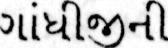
ગાંધીજીની
